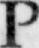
P
